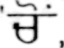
'ਚੋਂ,
